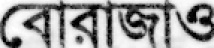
বোরাজাও
